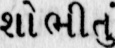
શોભીતું
